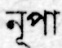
নূপা
